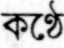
কণ্ঠে
